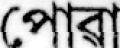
পোৱা
